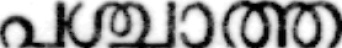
പശ്ചാത്ത
